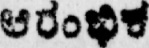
ಆರಂಭಿಕ
